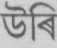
উৰি
